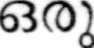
ഒരു
